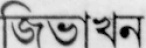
জিভাখন
